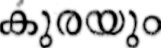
കുരയും
